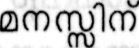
മനസ്സിന്
